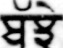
ਬੱਝੇ
